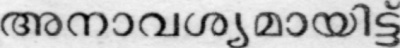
അനാവശ്യമായിട്ട്
